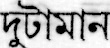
দুটামান
